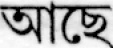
আছে
